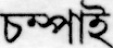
চম্পাই
